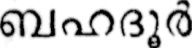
ബഹദൂര്‍
